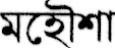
মহৌশা
